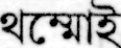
থম্মোই
